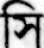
সি
